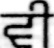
ਵੀ
